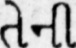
તેની
